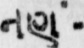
નણં-
